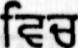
ਵਿਚ
